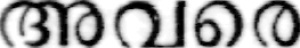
അവരെ
